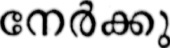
നേര്‍ക്കു
